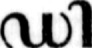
ഡി
